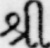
શ્રી
